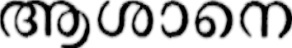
ആശാനെ
